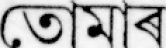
তোমাৰ
